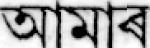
আমাৰ
